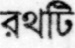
রথটি
